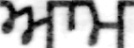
ਆਮ
